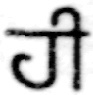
ਹੀ
